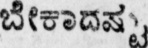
ಬೇಕಾದಷ್ಟು
